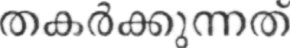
തകര്‍ക്കുന്നത്
